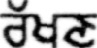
ਰੱਖਣ
